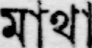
মাথা
